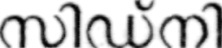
സിഡ്നി
